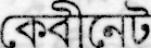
কেবীনেট
